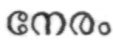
നേരം
